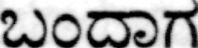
ಬಂದಾಗ
